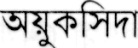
অয়ুকসিদা
